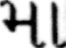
મા
